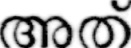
അത്
